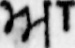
ਆ
